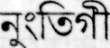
নুংতিগী
